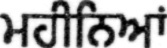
ਮਹੀਨਿਆਂ
